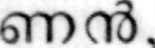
ണന്‍,
